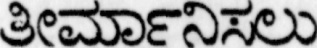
ತೀರ್ಮಾನಿಸಲು
